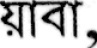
য়াবা,
